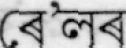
ৰে'লৰ
